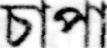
চাপা
